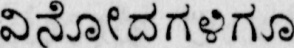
ವಿನೋದಗಳಿಗೂ
